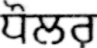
ਧੌਲਰ
